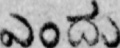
ಎಂದು
